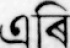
এৰি
